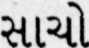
સાચો
